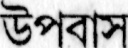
উপবাস
